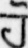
ਹੋ
